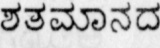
ಶತಮಾನದ
